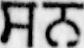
ਸਨ
